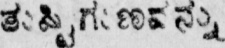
ತುಷ್ಟಿಗುಣವನ್ನು
